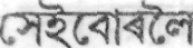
সেইবোৰলৈ
